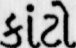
કાંટો
